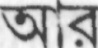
আর
